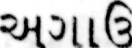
અગાઉ
